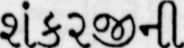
શંકરજીની
